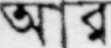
আর
